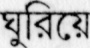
ঘুরিয়ে
